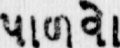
પાળવો
